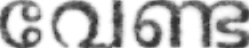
വേണ്ട
